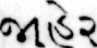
જાહેર
